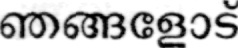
ഞങ്ങളോട്
